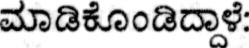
ಮಾಡಿಕೊಂಡಿದ್ದಾಳೆ:
